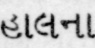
હાલના
